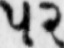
પર
